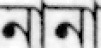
নানা
